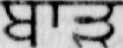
ਬਾੜ
